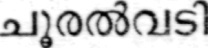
ചൂരല്‍വടി
